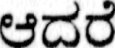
ಆದರೆ
